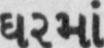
ઘરમાં
